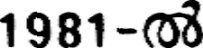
1981-ല്‍
